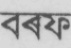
বৰফ
